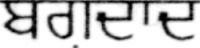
ਬਗ਼ਦਾਦ
